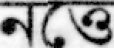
নত্তে
